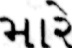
મારે
